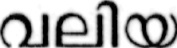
വലിയ
